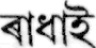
ৰাধাই
